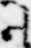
ને
